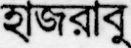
হাজরাবু
